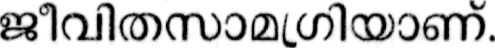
ജീവിതസാമഗ്രിയാണ്.
